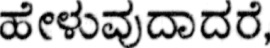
ಹೇಳುವುದಾದರೆ,
